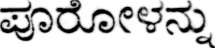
ಪೂರೋಳನ್ನು
